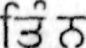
ਤਿੰਨ
